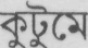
কুটুমে
